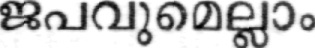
ജപവുമെല്ലാം
